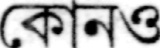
কোনও
